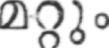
മറ്റും
